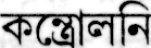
কন্ত্রোলনি
